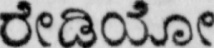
ರೇಡಿಯೋ
